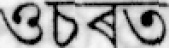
ওচৰত
